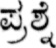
ಪ್ರಶ್ನೆ
